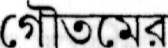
গৌতমের
